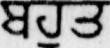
ਬਹੁਤ
